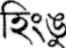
হিংঙু
